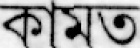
কামত
